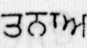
ਤਨਾਅ
